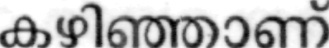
കഴിഞ്ഞാണ്
